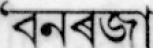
'বনৰজা
